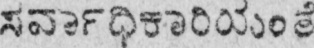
ಸರ್ವಾಧಿಕಾರಿಯಂತೆ
